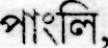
পাংলি,
